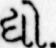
દ્યો.
